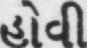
હોવી
